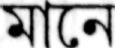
মানে
